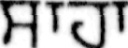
ਸਾਹਾ
